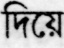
দিয়ে
